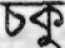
চকু
